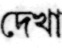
দেখা
